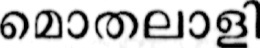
മൊതലാളി
